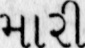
મારી
